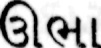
ઊભા
